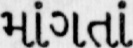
માંગતાં
